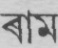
ৰাম
